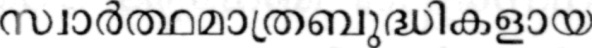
സ്വാര്‍ത്ഥമാത്രബുദ്ധികളായ
